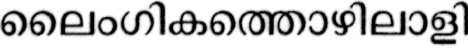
ലൈംഗികത്തൊഴിലാളി
